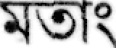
মতাং
